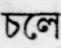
চলে
